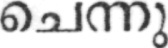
ചെന്നു
